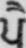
ਪੈ
